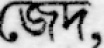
জেদ,
